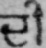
ਦੀ
